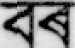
বৰ
